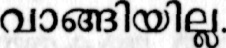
വാങ്ങിയില്ല.
